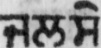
ਜਲਸੇ
